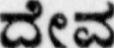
ದೇವ
